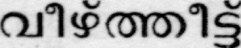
വീഴ്ത്തീട്ട്
